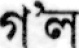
গ'ল
